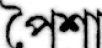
পৈশা
